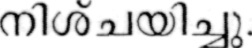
നിശ്ചയിച്ചു.
